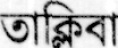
তাক্লিবা
